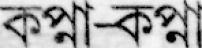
কপ্না-কপ্না
